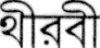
থীরবী
